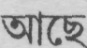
আছে
